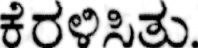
ಕೆರಳಿಸಿತು.
